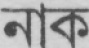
নাক
